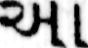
આ
